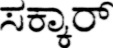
ಸಕ್ಕಾರ್
